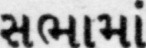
સભામાં
